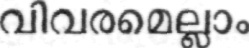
വിവരമെല്ലാം
